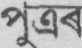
পুত্রৰ
